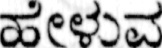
ಹೇಳುವ
